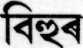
বিহুৰ
